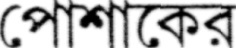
পোশাকের
